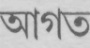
আগত
